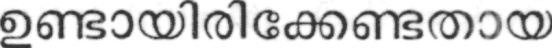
ഉണ്ടായിരിക്കേണ്ടതായ
